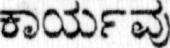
ಕಾರ್ಯವು
